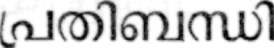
പ്രതിബന്ധി
